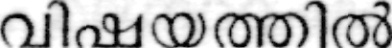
വിഷയത്തില്‍
